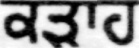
ਕੜਾਹ
